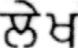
ਲੇਖ
